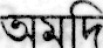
অমদি
